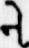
ને
